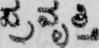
ಪ್ರವೃತ್ತಿ
